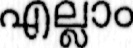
എല്ലാം
